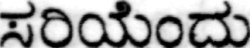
ಸರಿಯೆಂದು
